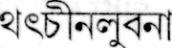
থৎচীনলুবনা
